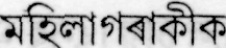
মহিলাগৰাকীক
